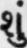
શું
